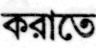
করাতে
